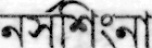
নর্সশিংনা
